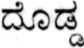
ದೊಡ್ಡ
